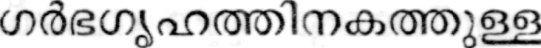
ഗര്‍ഭഗൃഹത്തിനകത്തുള്ള
